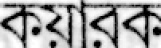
কয়ারক
